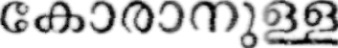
കോരാനുള്ള
